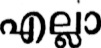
എല്ലാ
